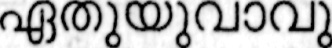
ഏതുയുവാവു
